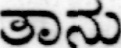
ತಾನು
